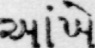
આંખે
